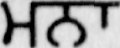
ਮਨਾ
